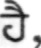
ਹੈ,
